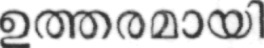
ഉത്തരമായി
